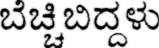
ಬೆಚ್ಚಿಬಿದ್ದಳು
